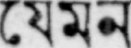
যেমন
